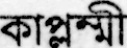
কাপ্লম্মী
